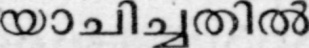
യാചിച്ചതില്‍
